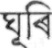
ঘূৰি
